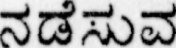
ನಡೆಸುವ
